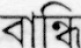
বান্ধি
